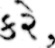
કરે,
